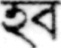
হব
